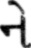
ને
